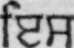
ਇਸ
